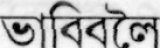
ভাবিবলৈ
